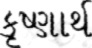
કૃષ્ણાર્થ
